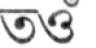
তওঁ
